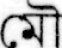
মৌ
